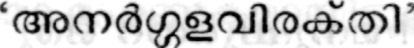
'അനര്‍ഗ്ഗളവിരക്തി'
